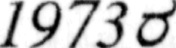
1973ರ
